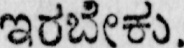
ಇರಬೇಕು.
